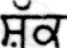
ਸ਼ੱਕ
